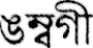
ঙম্বগী
